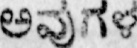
ಅವುಗಳ
